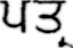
ਪਤ੍ਰ
